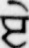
ਏ
